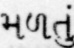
મળતું
